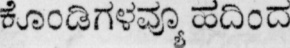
ಕೊಂಡಿಗಳವ್ಯೂಹದಿಂದ
